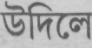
উদিলে
